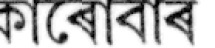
কাৰোবাৰ
